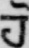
ਹੋ
